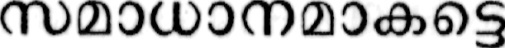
സമാധാനമാകട്ടെ
